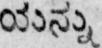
ಯನ್ನು
